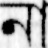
না
